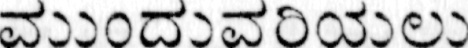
ಮುಂದುವರಿಯಲು
